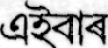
এইবাৰ
